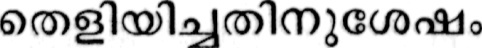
തെളിയിച്ചതിനുശേഷം
